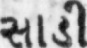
સાડી
